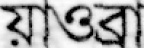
য়াওব্রা
